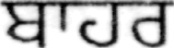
ਬਾਹਰ
